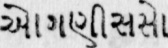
ઓગણીસસો
